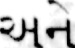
અને
